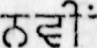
ਨਵੀਂ
